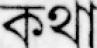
কথা
